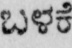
ಬಳಕೆ
